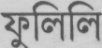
ফুলিলি
